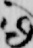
છે
